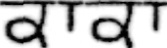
ਕਾਕਾ
